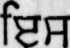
ਇਸ
